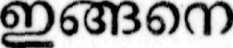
ഇങ്ങനെ
